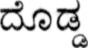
ದೊಡ್ಡ
